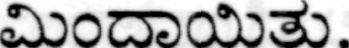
ಮಿಂದಾಯಿತು.
